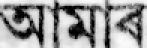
আমাৰ
